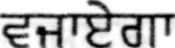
ਵਜਾਏਗਾ
